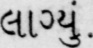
લાગ્યું.
